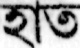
হাত
